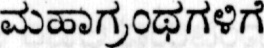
ಮಹಾಗ್ರಂಥಗಳಿಗೆ
